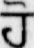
ਹੋ
